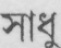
সাধু
